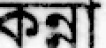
কন্না
